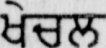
ਖੇਚਲ
